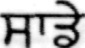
ਸਾਡੇ
